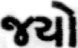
જયો
